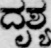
ದೃಶ್ಯ
